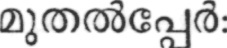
മുതല്‍പ്പേര്‍:
